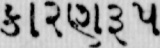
કારણરૂપ
